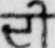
ਦੀ
